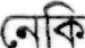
নেকি
